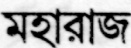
মহারাজ
